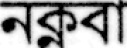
নক্নবা
